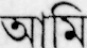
আমি
